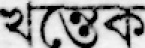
খন্তেক
